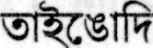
তাইঙোদি
